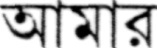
আমার
